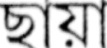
ছায়া
